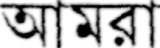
আমরা
